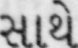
સાથે
